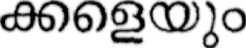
ക്കളെയും
